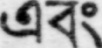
এবং
